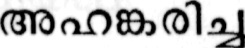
അഹങ്കരിച്ച
